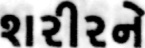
શરીરને
